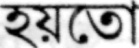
হয়তো
